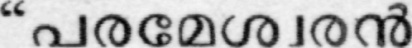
"പരമേശ്വരന്‍
